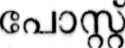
പോസ്റ്റ്
